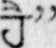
ਹੈ''
